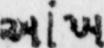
આંખ
